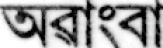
অৱাংবা
